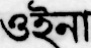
ওইনা
